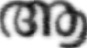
ആ
